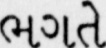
ભગતે
